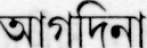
আগদিনা
